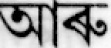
আৰু
